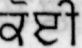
ਕੋਈ
